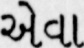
એવા
